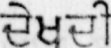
ਦੇਖਦੀ
